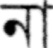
না
